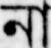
না
